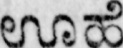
ಊಹೆ
